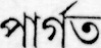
পার্গত
